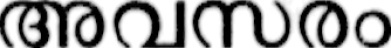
അവസരം
